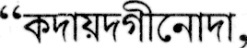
“কদায়দগীনোদা,
